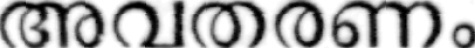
അവതരണം
